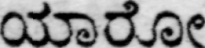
ಯಾರೋ
